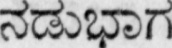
ನಡುಭಾಗ
